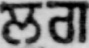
ਲਗ਼
